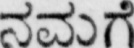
ನಮಗೆ
